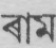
ৰাম
